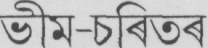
ভীম-চৰিতৰ
